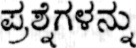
ಪ್ರಶ್ನೆಗಳನ್ನು
